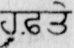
ਹਫ਼ਤੇ
